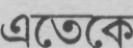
এতেকে
